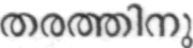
തരത്തിനു
